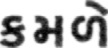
કમળે
